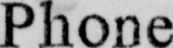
Phone
